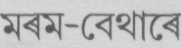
মৰম-বেথাৰে
